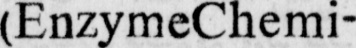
(Ennymechemi
